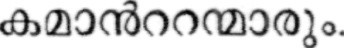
കമാന്ററന്മാരും.
